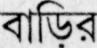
বাড়ির
